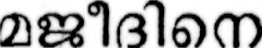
മജീദിനെ
